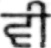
ਵੀ
